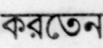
করতেন
